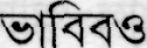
ভাবিবও
